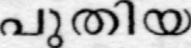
പുതിയ
